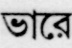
ভারে
